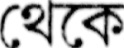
থেকে
